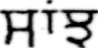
ਸਾਂਝ
